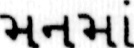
મનમાં
